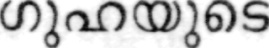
ഗുഹയുടെ
